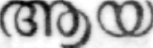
ആയ
